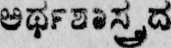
ಅರ್ಥಶಾಸ್ತ್ರದ
